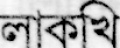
লাকখি
